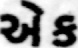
એક
